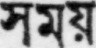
সময়
